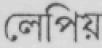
লেপিয়
